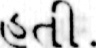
હતી.
